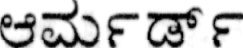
ಆರ್ಮರ್ಡ್
